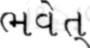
ભવેત્
